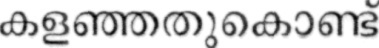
കളഞ്ഞതുകൊണ്ട്
